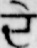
ਦੇ
